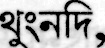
থুংনদি,
